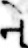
ને
